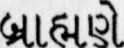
બ્રહ્મણે
